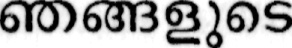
ഞങ്ങളുടെ
